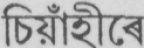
চিয়াঁহীৰে
